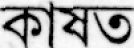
কাষত
